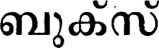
ബുക്സ്
